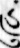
હું
